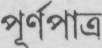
পূৰ্ণপাত্ৰ
